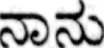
ನಾನು
